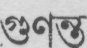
গুণন্ত
